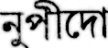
নুপীদো
